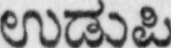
ಉಡುಪಿ
